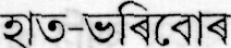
হাত-ভৰিবোৰ
